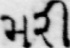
મરી
